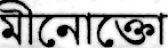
মীনোক্তো
